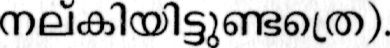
നല്കിയിട്ടുണ്ടത്രെ).
